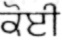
ਕੋਈ
